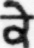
ਕੇ
